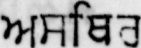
ਅਸਥਿਰ
